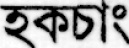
হকচাং
